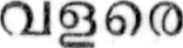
വളരെ
